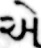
એ
